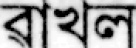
ৱাখল
